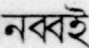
নব্বই
